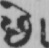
છો
